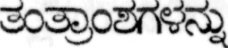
ತಂತ್ರಾಂಶಗಳನ್ನು
